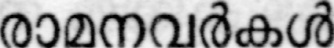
രാമനവര്‍കള്‍
